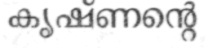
കൃഷ്ണന്റെ
